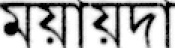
ময়ায়দা
